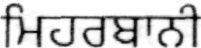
ਮਿਹਰਬਾਨੀ
